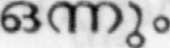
ഒന്നും
